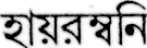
হায়রম্বনি
